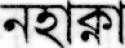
নহাক্না
